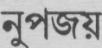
নুপজয়
